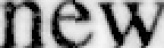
new
